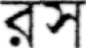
রস
